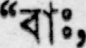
‘‘বাঃ,
